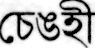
চেঙহী
